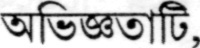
অভিজ্ঞতাটি,
